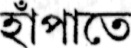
হাঁপাতে
